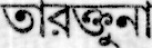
তারক্তুনা
